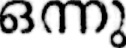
ഒന്നു
